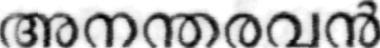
അനന്തരവന്‍
